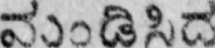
ಮಂಡಿಸಿದ
